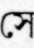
সে
